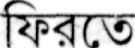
ফিরতে
